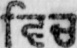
ਵਿਚ
